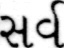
સર્વ
